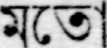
মতো
